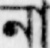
না
